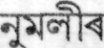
নুমলীৰ
